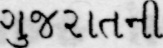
ગુજરાતની
